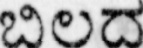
ಬಿಲದ
